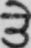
ਤੇ
